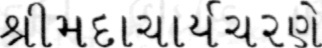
શ્રીમદાચાર્યચરણે
